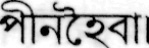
পীনহৈবা।
